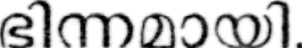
ഭിന്നമായി.
